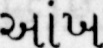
આંખ
